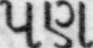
પણ
